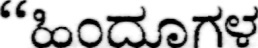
"ಹಿಂದೂಗಳ
